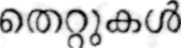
തെറ്റുകള്‍
